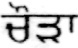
ਚੌੜਾ
